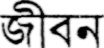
জীবন
